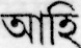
আহি
